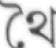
থৈ
